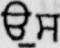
ਉਸ
